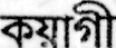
কয়াগী
